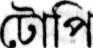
টোপি
